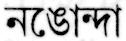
নঙোন্দা
